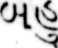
બહુ
